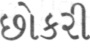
છોકરી
